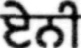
ਏਨੀ
